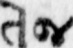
તેજ
